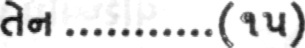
તેન.............(૧૫)
